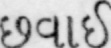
છવાઈ
